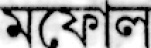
মফোল
